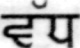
ਵੱਧ
